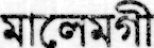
মালেমগী
